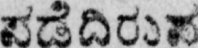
ಪಡೆದಿರುವ
